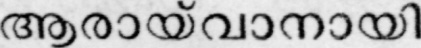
ആരായ്വാനായി
